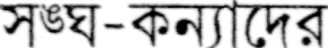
সঙ্ঘ-কন্যাদের
